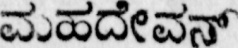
ಮಹದೇವನ್
